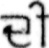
ਦੀ
